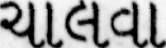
ચાલવા
